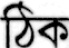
ঠিক
